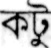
কটু
